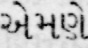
એમણે
